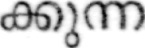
ക്കുന്ന
